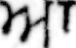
ਆ
